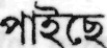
পাইছে
